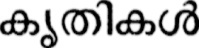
കൃതികള്‍
